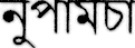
নুপামচা
